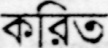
করিত
